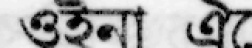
ওইনা
